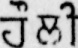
ਹੌਲੀ
